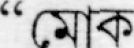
"মোক
